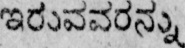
ಇರುವವರನ್ನು
